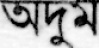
অদুম
